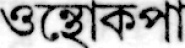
ওন্থোকপা
